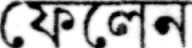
ফেলেন
